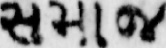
સમાજ
